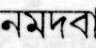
নমদবা
